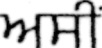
ਅਸੀਂ
